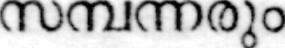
സമ്പന്നരും
